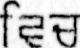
ਵਿਚ
